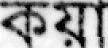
কয়া
